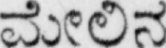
ಮೇಲಿನ
